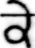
ਕੇ
